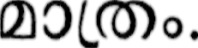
മാത്രം.
